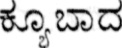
ಕ್ಯೂಬಾದ
